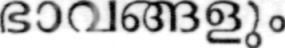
ഭാവങ്ങളും
